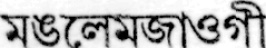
মঙলেমজাওগী
